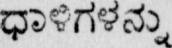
ಧಾಳಿಗಳನ್ನು
